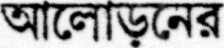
আলোড়নের
